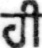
ਹੀ
